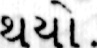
થયો.
